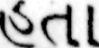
હતા
